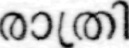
രാത്രി
